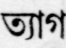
ত্যাগ
